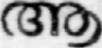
ആ
